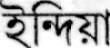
ইন্দিয়া
